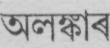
অলঙ্কাৰ
